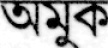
অমুক
